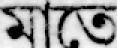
মাতে
